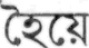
হৈয়ে
